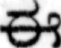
ಈ
